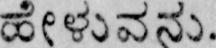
ಹೇಳುವನು.
